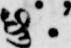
છું.'
